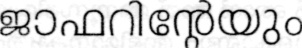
ജാഫറിന്റേയും
